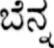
ಬೆನ್ನ
